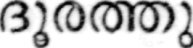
ദൂരത്തു
